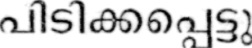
പിടിക്കപ്പെട്ടു
